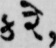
કરે,
